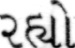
રહ્યો
